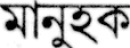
মানুহক
